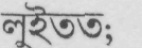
লুইতত;
